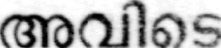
അവിടെ
